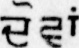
ਦੋਵਾਂ
